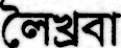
লৈখ্রবা
